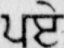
ਪਏ
